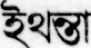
ইথন্তা
